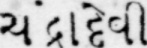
ચંદ્રાદેવી
